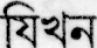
যিখন
